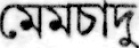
মেমচাদু
